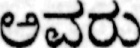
ಅವರು
